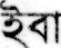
ইবা
